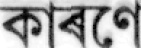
কাৰণে
